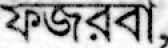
ফজরবা,
